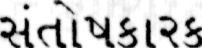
સંતોષકારક
